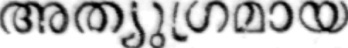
അത്യുഗ്രമായ
